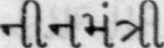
નીનમંત્રી
